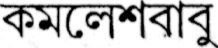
কমলেশবাবু
